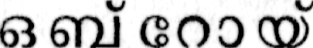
ഒബ്റോയ്
